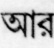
আর
